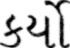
કર્યો
